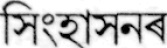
সিংহাসনৰ
